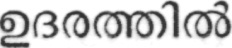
ഉദരത്തില്‍
